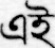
এই
